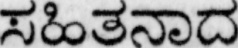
ಸಹಿತನಾದ
